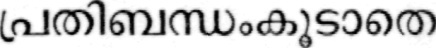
പ്രതിബന്ധംകൂടാതെ
